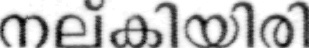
നല്കിയിരി
